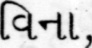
વિના,
